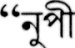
“নুপী
